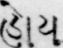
હોય
